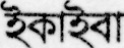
ইকাইবা
